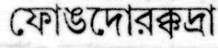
ফোঙদোরক্কদ্রা
